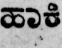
ಹಾಕಿ
